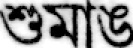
শুমাঙ
